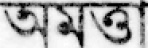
অমত্তা
